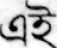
এই
